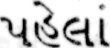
પહેલાં
